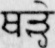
ਥੜ੍ਹੇ
